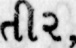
તીર,
